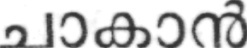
ചാകാന്‍
